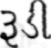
રૂડી
